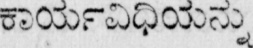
ಕಾರ್ಯವಿಧಿಯನ್ನು
